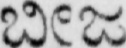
ಬೀಜ
